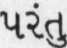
પરંતુ
